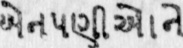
બેનપણીઓને
